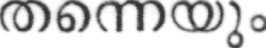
തന്നെയും
